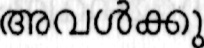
അവള്‍ക്കു
